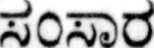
ಸಂಸಾರ
